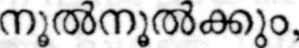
നൂല്‍നൂല്‍ക്കും,
